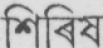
শিৰিষ
